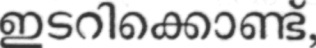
ഇടറിക്കൊണ്ട്,
